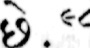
છે.૯૮
